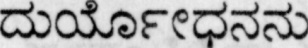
ದುರ್ಯೋಧನನು
